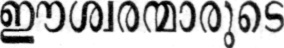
ഈശ്വരന്മാരുടെ
